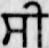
ਸੀ
